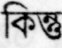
কিন্তু
